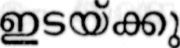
ഇടയ്ക്കു
